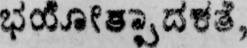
ಭಯೋತ್ಪಾದಕತೆ,
